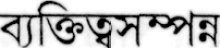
ব্যক্তিত্বসম্পন্ন
